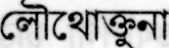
লৌথোক্তুনা
